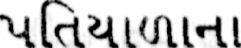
પતિયાળાના
